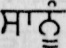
ਸਾਨੂੰ
